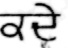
ਕਦੇ
